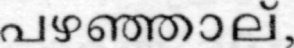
പഴഞ്ഞാല്,
